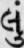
લું
